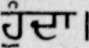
ਹੁੰਦਾ।
